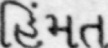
હિંમત
